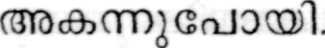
അകന്നുപോയി.
